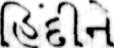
હિંદીને
